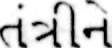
તંત્રીને
